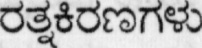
ರತ್ನಕಿರಣಗಳು
